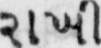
રાખી
